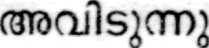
അവിടുന്നു
